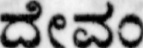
ದೇವಂ
